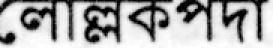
লোল্লকপদা
